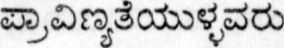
ಪ್ರಾವಿಣ್ಯತೆಯುಳ್ಳವರು
